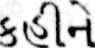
કહીને
